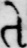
તે
